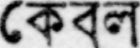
কেবল
